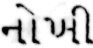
નોખી
